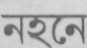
নহনে
